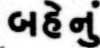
બહેનું
